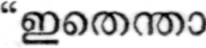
“ഇതെന്താ
